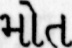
મોત
